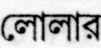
লোলার
